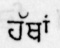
ਹੱਥਾਂ
